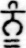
ਨੂੰ
